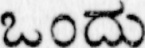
ಒಂದು
